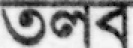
তলব
